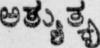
ಅತ್ಯುತ್ಕೃ
